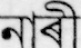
নাৰী
